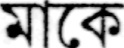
মাকে
